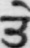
ਤੇ
